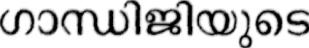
ഗാന്ധിജിയുടെ
